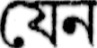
যেন
